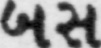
બસ
